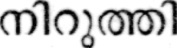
നിറുത്തി
